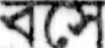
বসে
